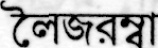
লৈজরম্বা
